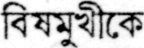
বিষমুখীকে
